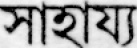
সাহায্য
